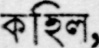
কহিল,
